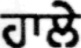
ਹਾਲੇ
